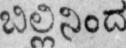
ಬಿಲ್ಲಿನಿಂದ
